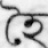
হৈ
